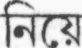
নিয়ে
